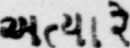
અત્યારે
